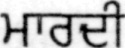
ਮਾਰਦੀ
